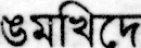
ঙমখিদে
